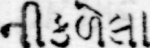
નીકળેલા
